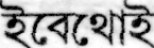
ইবেথোই
